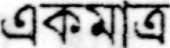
একমাত্র
